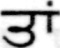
ਤਾਂ
